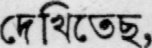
দেখিতেছ,
